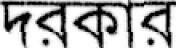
দরকার
